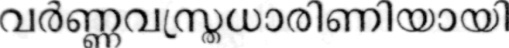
വര്‍ണ്ണവസ്ത്രധാരിണിയായി
